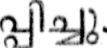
പ്പിച്ചു.
